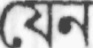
যেন
